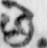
છે.
